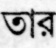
তার
